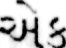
એક
